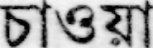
চাওয়া
